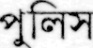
পুলিস
